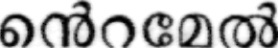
ന്റെമേല്‍
